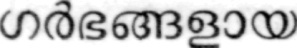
ഗര്‍ഭങ്ങളായ
